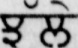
ਝੱਲੇ
